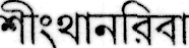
শীংথানরিবা
